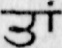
ਤਾਂ
